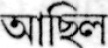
আছিল
